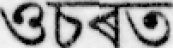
ওচৰত
